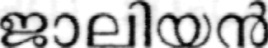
ജാലിയന്‍
